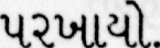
પરખાયો.
